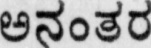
ಅನಂತರ
